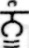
ਨੂੰ
